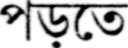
পড়তে
